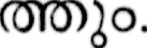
ത്തും.
